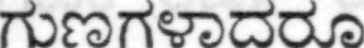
ಗುಣಗಳಾದರೂ
